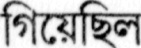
গিয়েছিল
